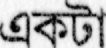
একটা
